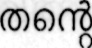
തന്റെ
